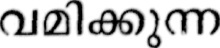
വമിക്കുന്ന
